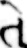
તે
